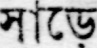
সাড়ে
